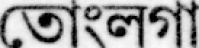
তোংলগা
